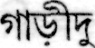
গাড়ীদু
